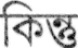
কিন্তু
